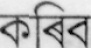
কৰিব
